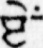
ਏਂ
